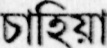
চাহিয়া
